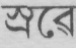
স্ৰৱে
